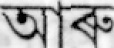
আৰু
